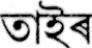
তাইৰ
